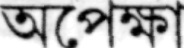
অপেক্ষা
